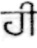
ਹੀ
